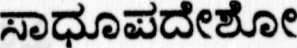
ಸಾಧೂಪದೇಶೋ
